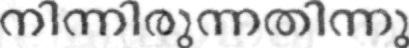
നിന്നിരുന്നതിന്നു
